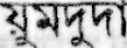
য়ুমদুদা
